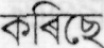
কৰিছে
